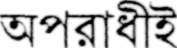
অপরাধীই
